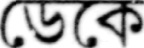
ডেকে
